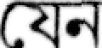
যেন
